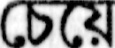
চেয়ে
